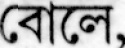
বোলে,
